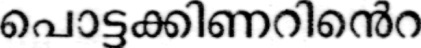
പൊട്ടക്കിണറിന്റെ
